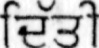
ਦਿੱਤੀ
